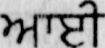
ਆਈ
